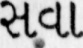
સવા
